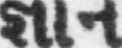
જ્ઞાન
